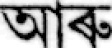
আৰু
